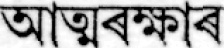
আত্মৰক্ষাৰ
